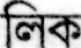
লিক
